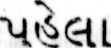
પહેલા
